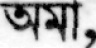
অমা,
